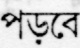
পড়বে
